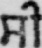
ਸੀ
